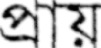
প্রায়
